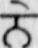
ਨੇ
